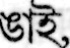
ঙাই,
